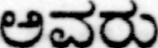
ಅವರು
